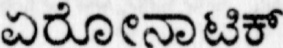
ಏರೋನಾಟಿಕ್
